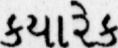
કયારેક
